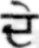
ਦੇ
